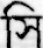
সি
